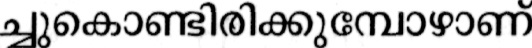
ച്ചുകൊണ്ടിരിക്കുമ്പോഴാണ്
